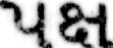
પક્ષ
